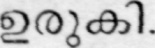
ഉരുകി.
